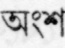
অংশ
